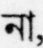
না,
